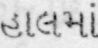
હાલમાં
